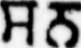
ਸਨ
